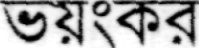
ভয়ংকর
